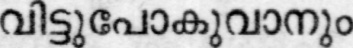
വിട്ടുപോകുവാനും
